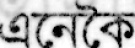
এনেকৈ
